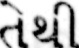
તેથી
